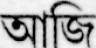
আজি
